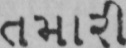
તમારી
